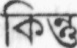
কিন্তু
